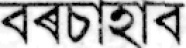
বৰচাহাব
